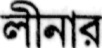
লীনার
